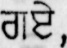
ਗਏ,
